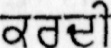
ਕਰਦੀ
